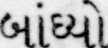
બાંધ્યો
